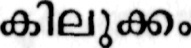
കിലുക്കം
